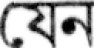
যেন
